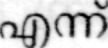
എന്ന്
